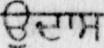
ਉਦਾਸ
